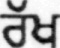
ਰੱਖ
